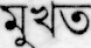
মুখত
